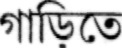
গাড়িতে
